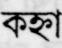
কহ্না
